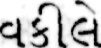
વકીલે
